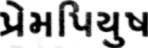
પ્રેમપિયુષ
